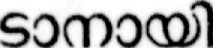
ടാനായി
